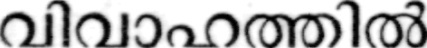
വിവാഹത്തില്‍
